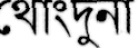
থোংদুনা
